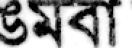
ঙমবা
